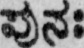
ಪುನಃ
